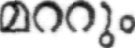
മററും
